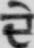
ਦੇ
